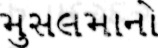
મુસલમાનો
